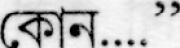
কোন...."
